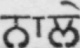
ਨਾਲੇ
